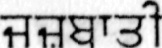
ਜਜ਼ਬਾਤੀ
